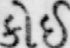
કોઈ
